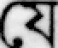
যে
